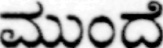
ಮುಂದೆ
